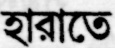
হারাতে
